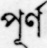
পূর্ণ
